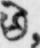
છે
